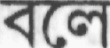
বলে
